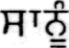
ਸਾਨੂੰ
